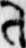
તે
